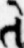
તે
